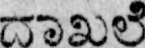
ದಾಖಲೆ
